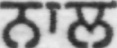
ਨਾਲ
